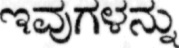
ಇವುಗಳನ್ನು
